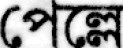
পেল্লে
